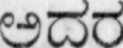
ಅದರ
